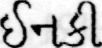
ઈનકી
